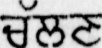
ਚੱਲਣ
